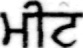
ਮੀਟ
